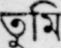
তুমি
